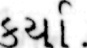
કર્યા.
